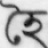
হৈ
